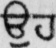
ਉਹ
